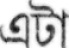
এটা
